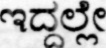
ಇದ್ದಲ್ಲೇ
